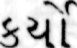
કર્યો
